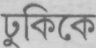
ঢুকিকে
